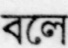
বলে
